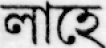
লাহে
